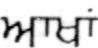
ਆਖਾਂ
